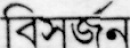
বিসর্জন
